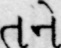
તને
